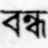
বন্ধ
